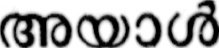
അയാള്‍
